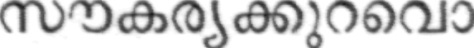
സൌകര്യക്കുറവൊ
